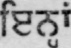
ਇਨ੍ਹਾਂ
